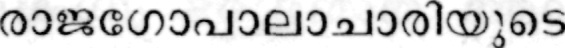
രാജഗോപാലാചാരിയുടെ
